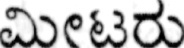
ಮೀಟರು
